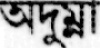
অদুম্না
